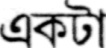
একটা
